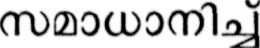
സമാധാനിച്ച്
